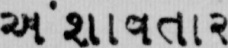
અંશાવતાર
